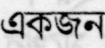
একজন
